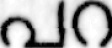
പറ
